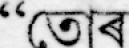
"তোৰ
